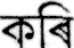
কৰি
